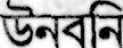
উনবনি
